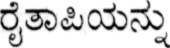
ರೈತಾಪಿಯನ್ನು
